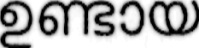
ഉണ്ടായ
